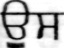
ਉਸ
